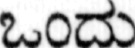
ಒಂದು
